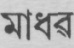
মাধৱ
